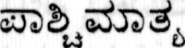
ಪಾಶ್ಚಿಮಾತ್ಯ
